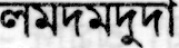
লমদমদুদা
